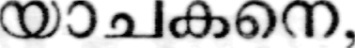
യാചകനെ,
